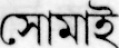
সোমাই
